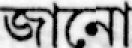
জানো
